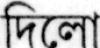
দিলো
